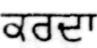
ਕਰਦਾ
